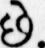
છે.
